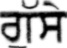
ਗੁੱਸੇ
